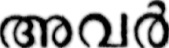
അവര്‍
